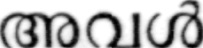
അവള്‍
